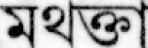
মথক্তা
